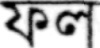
ফল
